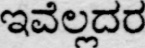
ಇವೆಲ್ಲದರ
